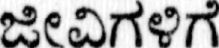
ಜೀವಿಗಳಿಗೆ
